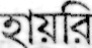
হায়রি
